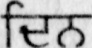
ਦਿਨ
